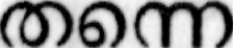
തന്നെ
